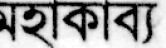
মহাকাব্য
